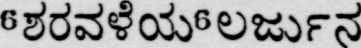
6ಶರವಳೆಯ6ಲರ್ಜುನ
